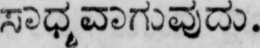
ಸಾಧ್ಯವಾಗುವುದು.
